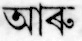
আৰু
